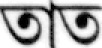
তাত
